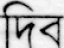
দিব
